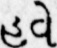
હવે
